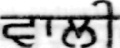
ਵਾਲੀ
